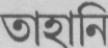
তাহানি
